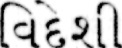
વિદેશી
